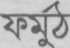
ফৰ্মুঠ
